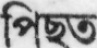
পিছত
